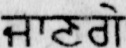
ਜਾਣਗੇ
